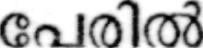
പേരില്‍
